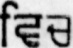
ਵਿਚ
